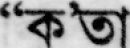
"ক'তা
